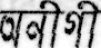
অনীগী
